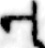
ન
